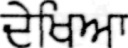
ਦੇਖਿਆ
